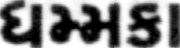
ધમ્મકા
